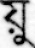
য়ু
